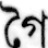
গৈ
